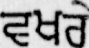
ਵਖਰੇ
